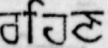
ਰਹਿਣ
